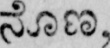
ನೊಣ,
